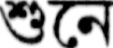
শুনে
